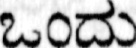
ಒಂದು
